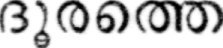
ദൂരത്തെ
